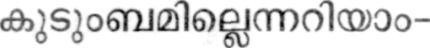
കുടുംബമില്ലെന്നറിയാം-
